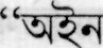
"অইন
